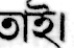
তাই।
